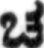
ಚ
